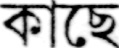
কাছে
